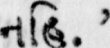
નહિ.'
